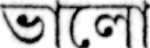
ভালো
